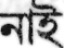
নাই
